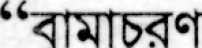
“বামাচরণ
